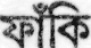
ফাঁকি
